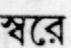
স্বরে
